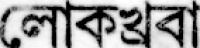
লোকখ্রবা
